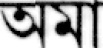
অমা
